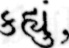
કહ્યું,
